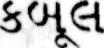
કબૂલ
